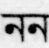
নন
